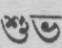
শুভ
